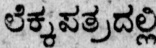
ಲೆಕ್ಕಪತ್ರದಲ್ಲಿ
